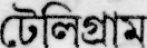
টেলিগ্রাম
